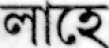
লাহে
